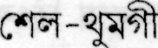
শেল-থুমগী
